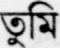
তুমি
